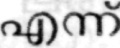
എന്ന്
